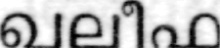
ഖലീഫ
